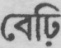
বেঢ়ি
